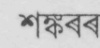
শঙ্কৰৰ
